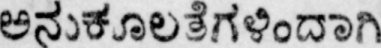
ಅನುಕೂಲತೆಗಳಿಂದಾಗಿ
